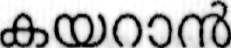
കയറാന്‍
